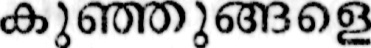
കുഞ്ഞുങ്ങളെ
